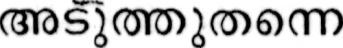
അടുത്തുതന്നെ
